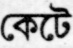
কেটে
